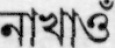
নাখাওঁ
